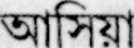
আসিয়া
